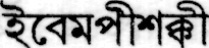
ইবেমপীশক্কী
